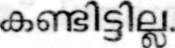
കണ്ടിട്ടില്ല.
